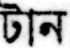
টান
